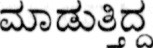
ಮಾಡುತ್ತಿದ್ದ
